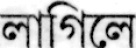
লাগিলে
